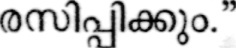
രസിപ്പിക്കും.”
